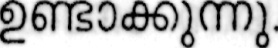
ഉണ്ടാക്കുന്നു.
